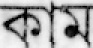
কাম
